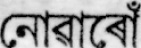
নোৱাৰোঁ
